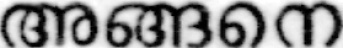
അങ്ങനെ
